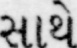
સાથે
